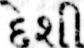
દેશી
